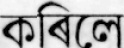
কৰিলে
